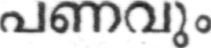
പണവും
